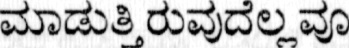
ಮಾಡುತ್ತಿರುವುದೆಲ್ಲವೂ
